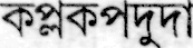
কপ্লকপদুদা
